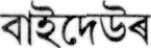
বাইদেউৰ
